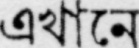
এখানে
